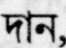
দান,
